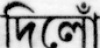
দিলোঁ
